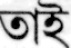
তাই
